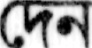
দেন
